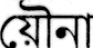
য়ৌনা
